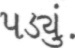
પડ્યું.
